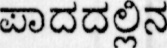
ಪಾದದಲ್ಲಿನ
